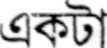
একটা
